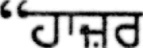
''ਹਾਜ਼ਰ
